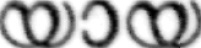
യായ
